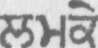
ਲਮਕੇ
